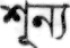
শূন্য
